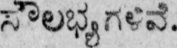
ಸೌಲಭ್ಯಗಳಿವೆ.
